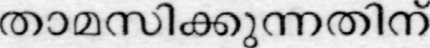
താമസിക്കുന്നതിന്
